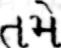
તમે
